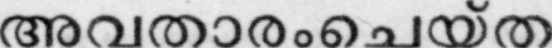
അവതാരംചെയ്ത
